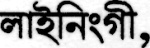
লাইনিংগী,
